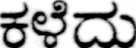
ಕಳೆದು
